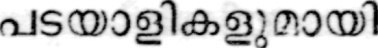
പടയാളികളുമായി
